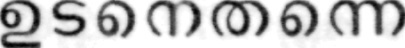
ഉടനെതന്നെ
